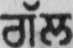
ਗੱਲ
